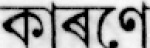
কাৰণে
